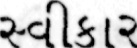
સ્વીકાર
